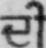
ਦੀ
